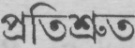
প্ৰতিশ্ৰুত
